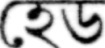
হেড
